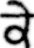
ਕੇ
